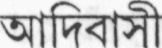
আদিবাসী
